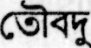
তৌবদু
